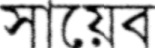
সায়েব
